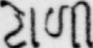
ટોળી
